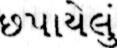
છપાયેલું
